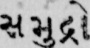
સમુદ્રો
